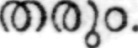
തരും.
